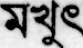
মখুৎ
